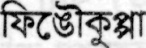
ফিঙৌকুপ্পা
